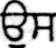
ਉਸ
